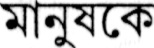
মানুষকে
